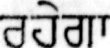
ਰਹੇਗਾ
